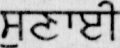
ਸੁਣਾਈ
